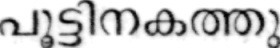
പൂട്ടിനകത്തു
